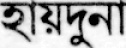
হায়দুনা
